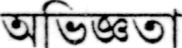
অভিজ্ঞতা
